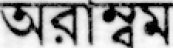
অরাম্বম
